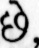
છે,
